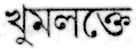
খুমলক্তে
